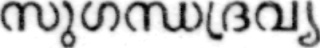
സുഗന്ധദ്രവ്യ
